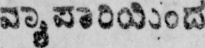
ವ್ಯಾಪಾರಿಯಿಂದ
